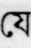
যে
